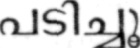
പടിച്ചൂ
